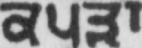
ਕਪੜਾ
